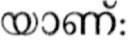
യാണ്:
